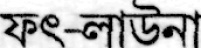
ফৎ-লাউনা
